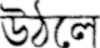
উঠলে
